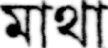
মাথা
